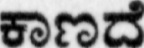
ಕಾಣದೆ
